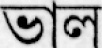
ভাল
